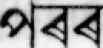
পৰৰ
